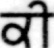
ਕੀ
